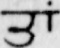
ਤਾਂ
